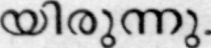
യിരുന്നു.
